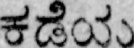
ಕಡೆಯ
